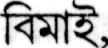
বিমাই,
